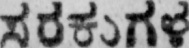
ಸರಕುಗಳ
